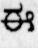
ಈ
